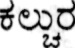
ಕಲ್ಚುರ
